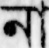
না
